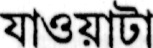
যাওয়াটা
